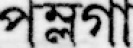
পম্লগা
